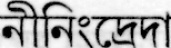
নীনিংদ্রেদা
